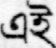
এই
